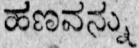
ಹಣವನ್ನು
